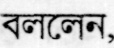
বললেন,
